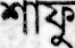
শাফু
